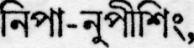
নিপা-নুপীশিং,
